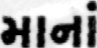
માનાં
